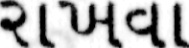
રાખવા
